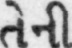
તેની
